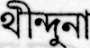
থীন্দুনা
